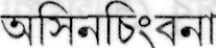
অসিনচিংবনা
